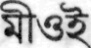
মীওই
